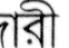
দারী
